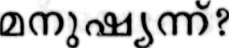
മനുഷ്യന്ന്?
